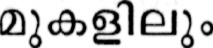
മുകളിലും
